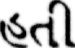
હતી
